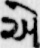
એ
